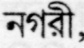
নগরী,
